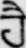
ਹੈ
